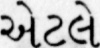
એટલે
